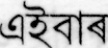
এইবাৰ
